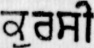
ਕੁਰਸੀ
